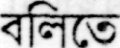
বলিতে
